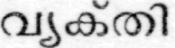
വ്യക്തി
